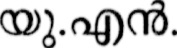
യു.എന്‍.
